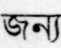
জন্য
